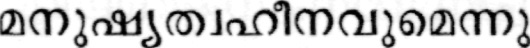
മനുഷ്യത്വഹീനവുമെന്നു
